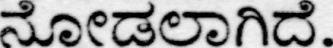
ನೊಡಲಾಗಿದೆ.
